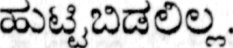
ಹುಟ್ಟಿಬಿಡಲಿಲ್ಲ.
